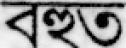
বহুত
